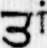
ਤਾਂ
